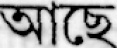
আছে
